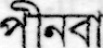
পীনবা
